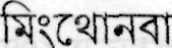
মিংথোনবা
